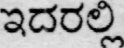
ಇದರಲ್ಲಿ
